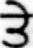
ਤੇ
